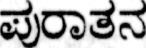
ಪುರಾತನ
